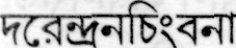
দরেন্দ্রনচিংবনা
